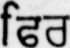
ਫਿਰ
